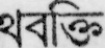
থবক্তি
